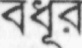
বধূর
